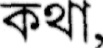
কথা,
